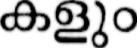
കളും
